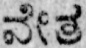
ವೇತ
